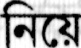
নিয়ে
